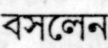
বসলেন
